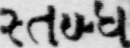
સ્તબ્ધ
